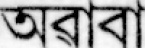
অৱাবা
